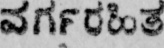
ವರ್ಗರಹಿತ
